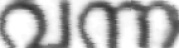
വന്ന
